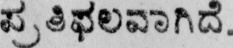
ಪ್ರತಿಫಲವಾಗಿದೆ.
